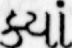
ક્યાં
